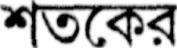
শতকের
